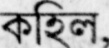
কহিল,
